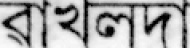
ৱাখলদা
